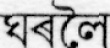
ঘৰলৈ
